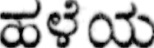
ಹಳೆಯ
